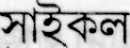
সাইকল
